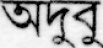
অদুবু
